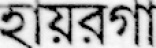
হায়রগা
